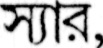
স্যার,
